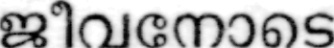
ജീവനോടെ
